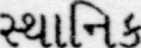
સ્થાનિક
